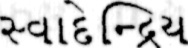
સ્વાદેન્દ્રિય
